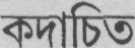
কদাচিত
